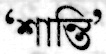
‘শান্তি’
